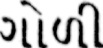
ગોળી
